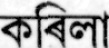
কৰিলা
